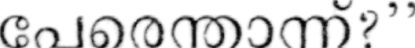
പേരെന്താന്ന്?"
